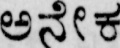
ಅನೇಕ
